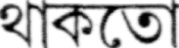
থাকতো
